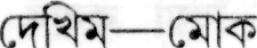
দেখিম-মোক
